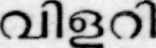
വിളറി
